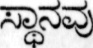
ಸ್ಥಾನವು
